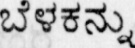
ಬೆಳಕನ್ನು
